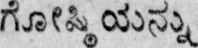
ಗೋಷ್ಠಿಯನ್ನು
